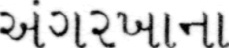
અંગરખાના
